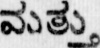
ಮತ್ತು
